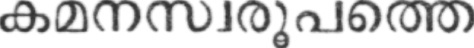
കമനസ്വരൂപത്തെ
